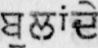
ਬੁਲਾਂਦੇ
